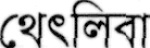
থেৎলিবা
